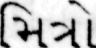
મિત્રો
